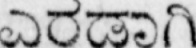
ಎರಡಾಗಿ
